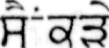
ਸੈਂਕੜੇ
